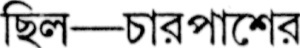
ছিল–চারপাশের
